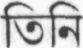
তিনি
